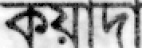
কয়াদা
